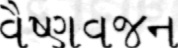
વૈષ્વજન
